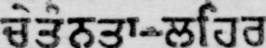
ਚੇਤੰਨਤਾ-ਲਹਿਰ
